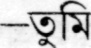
-তুমি
